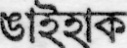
ঙাইহাক
